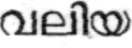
വലിയ
